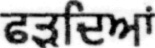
ਫੜਦਿਆਂ
